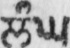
ਲੰਘ
